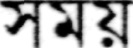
সময়
